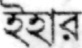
ইহার
